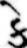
કે
